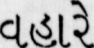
વહારે
